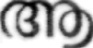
ആ
